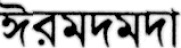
ঈরমদমদা
